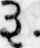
રૂ.
